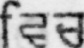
ਵਿਚ
